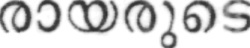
രായരുടെ
